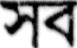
সব
